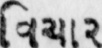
વિચાર
